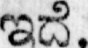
ಇದೆ.
